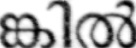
ങ്കില്‍
